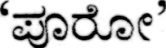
'ಪೂರೋ'
